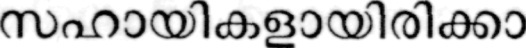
സഹായികളായിരിക്കാ
